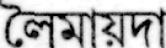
লৈমায়দা
